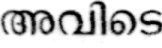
അവിടെ
